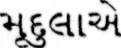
મૃદુલાએ
